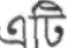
এটি
